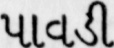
પાવડી
